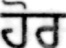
ਹੋਰ
